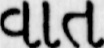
વાત
